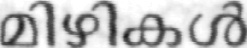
മിഴികള്‍
